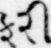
ફરી
